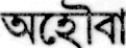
অহৌবা
